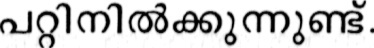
പറ്റിനില്‍ക്കുന്നുണ്ട്.
